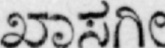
ಖಾಸಗೀ
